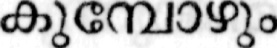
കുമ്പോഴും
